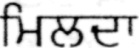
ਮਿਲਦਾ
